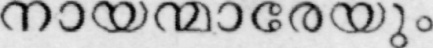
നായന്മാരേയും
